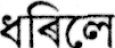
ধৰিলে
